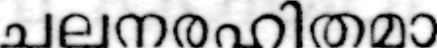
ചലനരഹിതമാ
